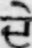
ਦੇ
